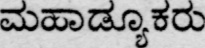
ಮಹಾಡ್ಯೂಕರು
